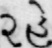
રહે
